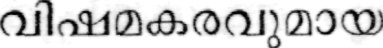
വിഷമകരവുമായ
